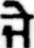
ਜੇ
